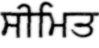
ਸੀਮਿਤ
